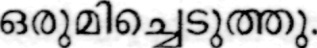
ഒരുമിച്ചെടുത്തു.
